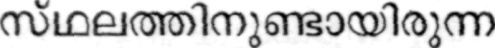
സ്ഥലത്തിനുണ്ടായിരുന്ന
